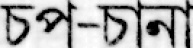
চপ-চানা
